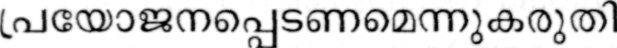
പ്രയോജനപ്പെടണമെന്നുകരുതി
